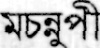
মচন্নুপী
